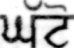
ਘੱਟੋ
